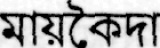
মায়কৈদা
